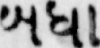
બધા
